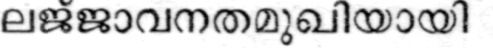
ലജ്ജാവനതമുഖിയായി
